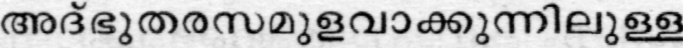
അദ്ഭുതരസമുളവാക്കുന്നിലുള്ള
